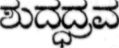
ಶುದ್ಧದ್ರವ
